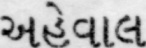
અહેવાલ
